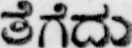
ತೆಗೆದು
